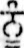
ਨੂੰ
